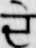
ਦੇ
